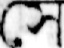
সে
